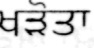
ਖੜੋਤਾ
